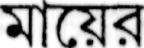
মায়ের
